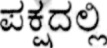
ಪಕ್ಷದಲ್ಲಿ
